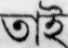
তাই
